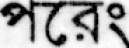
পরেং
